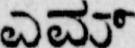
ಎಮ್
